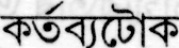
কর্তব্যটোক
